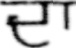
ਦਾ
